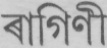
ৰাগিণী
